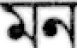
মন
